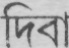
দিবা
